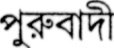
পুরুবাদী
